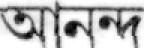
আনন্দ
